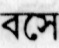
বসে
